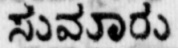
ಸುಮಾರು
